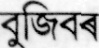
বুজিবৰ
